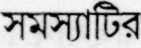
সমস্যাটির
